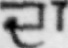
ਦਾ
